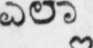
ಎಲ್ಲಾ
